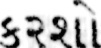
કરશો
